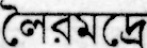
লৈরমদ্রে
